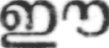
ഈ
